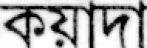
কয়াদা
